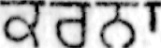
ਕਰਨਾ
